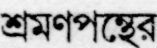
শ্রমণপন্থের
